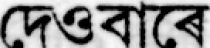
দেওবাৰে
